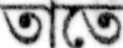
তাতে
